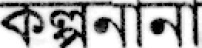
কল্পনানা
